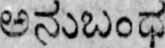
ಅನುಬಂಧ
